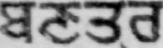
ਬਣਤਰ
